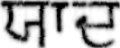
ਯਾਦ
